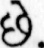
છે.
